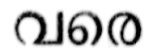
വരെ
